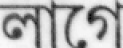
লাগে
